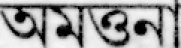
অমত্তনা
